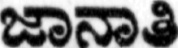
ಜಾನಾತಿ
